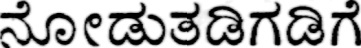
ನೋಡುತಡಿಗಡಿಗೆ
